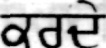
ਕਰਦੇ
